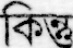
কিন্তু
